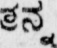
ತನ್ನ
